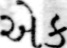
એક
